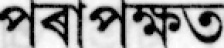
পৰাপক্ষত
